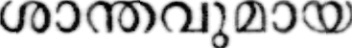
ശാന്തവുമായ
